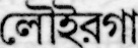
লোইরগা
